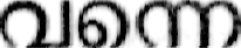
വന്നെ
